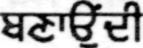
ਬਣਾਉਂਦੀ
